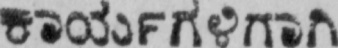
ಕಾರ್ಯಗಳಿಗಾಗಿ
